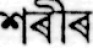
শৰীৰ
